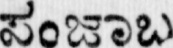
ಪಂಜಾಬ
